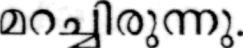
മറച്ചിരുന്നു.
